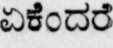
ಏಕೆಂದರೆ
